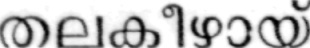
തലകീഴായ്
